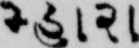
મ્હારા
